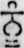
ਨੂੰ
